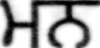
ਮਨ
